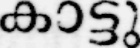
കാട്ടു
